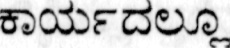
ಕಾರ್ಯದಲ್ಲೂ
